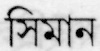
সিমান
